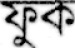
ফুক
